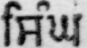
ਸਿੰਘ
